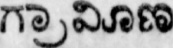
ಗ್ರಾಮೀಣ
